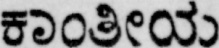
ಕಾಂತೀಯ
